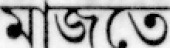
মাজতে
